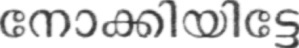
നോക്കിയിട്ടേ
